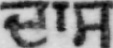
ਦਾਸ
